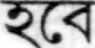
হবে
